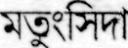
মতুংসিদা
